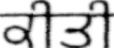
ਕੀਤੀ
